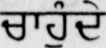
ਚਾਹੁੰਦੇ
